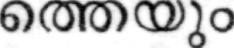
ത്തെയും
